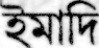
ইমাদি
